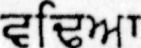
ਵਢਿਆ
